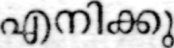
എനിക്കു
